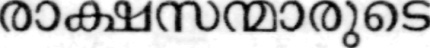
രാക്ഷസന്മാരുടെ
